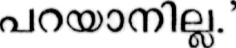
പറയാനില്ല.’
